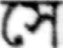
সে
